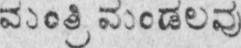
ಮಂತ್ರಿಮಂಡಲವು
